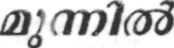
മുന്നില്‍
